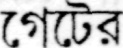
গেটের
